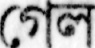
গেল
